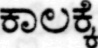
ಕಾಲಕ್ಕೆ
